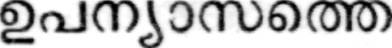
ഉപന്യാസത്തെ
